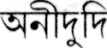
অনীদুদি
